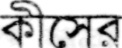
কীসের
